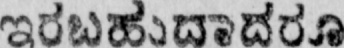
ಇರಬಹುದಾದರೂ
